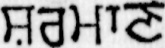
ਸ਼ਰਮਾਣ
